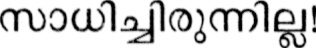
സാധിച്ചിരുന്നില്ല!
